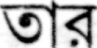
তার
